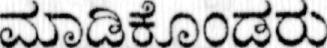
ಮಾಡಿಕೊಂಡರು
